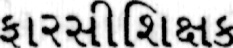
ફારસીશિક્ષક
